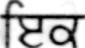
ਇਕ
